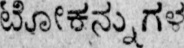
ಟೋಕನ್ನುಗಳ
